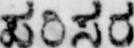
ಪರಿಸರ
